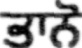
ਭਾਨੋ
